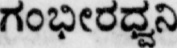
ಗಂಭೀರಧ್ವನಿ
